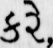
કરે,
